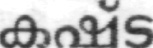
കഷ്ട
